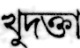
খুদক্তা
